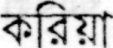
করিয়া
